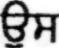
ਉਸ
